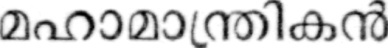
മഹാമാന്ത്രികന്‍
